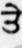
ਤੇ
